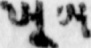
ખૂબ
